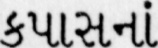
કપાસનાં
